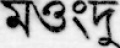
মওংদু
